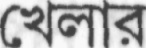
খেলার
